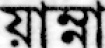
য়াম্না
